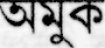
অমুক
